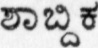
ಶಾಬ್ದಿಕ
